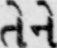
તેને
